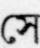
সে
